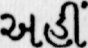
અહીં
